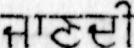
ਜਾਣਦੀ
